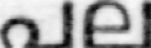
പല
